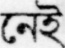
নেই
